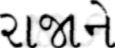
રાજાને
